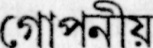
গোপনীয়
